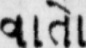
વાતો
